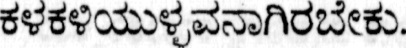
ಕಳಕಳಿಯುಳ್ಳವನಾಗಿರಬೇಕು.
